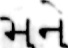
મને
